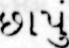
છાપું
